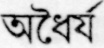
অধৈর্য
